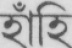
হাঁহি
